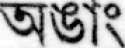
অঙাং
